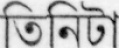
তিনিটা
